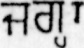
ਜਗ੍ਹਾ
